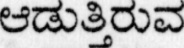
ಆಡುತ್ತಿರುವ
